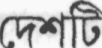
দেশটি
